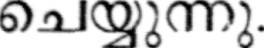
ചെയ്യുന്നു.
